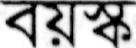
বয়স্ক
